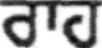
ਰਾਹ
